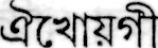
ঐখোয়গী
